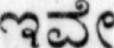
ಇವೇ
